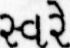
સ્વરે
